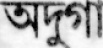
অদুগা
